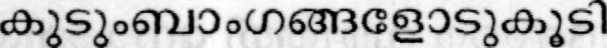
കുടുംബാംഗങ്ങളോടുകൂടി
